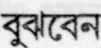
বুঝবেন
